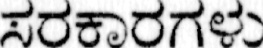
ಸರಕಾರಗಳು
